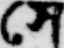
সে
